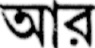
আর
